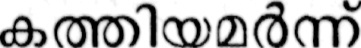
കത്തിയമര്‍ന്ന്
